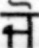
ਜੋ
